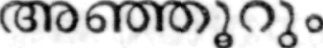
അഞ്ഞൂറും
